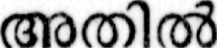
അതില്‍
